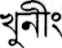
খুনীং
